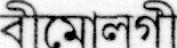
বীমোলগী
